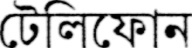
টেলিফোন
